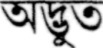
অদ্ভুত
